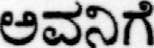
ಅವನಿಗೆ
